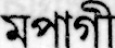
মপাগী
